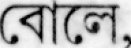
বোলে,
